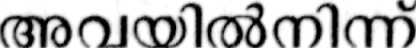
അവയില്‍നിന്ന്
